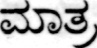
ಮಾತ್ರ
